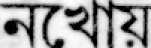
নখোয়
